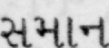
સમાન
